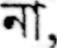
না,
